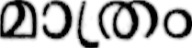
മാത്രം
